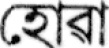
হোৱা
